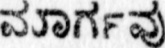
ಮಾರ್ಗವು
